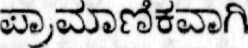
ಪ್ರಾಮಾಣಿಕವಾಗಿ
